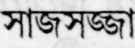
সাজসজ্জা
